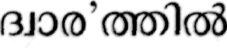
ദ്വാര’ത്തില്‍
